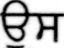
ਉਸ
